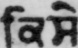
ਕਿਸੇ
